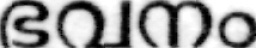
ഭവനം
